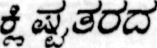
ಕ್ಲಿಷ್ಟತರದ
